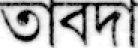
তাবদা
